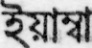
ইয়াম্বা
